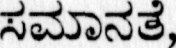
ಸಮಾನತೆ,
